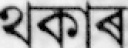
থকাৰ
